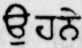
ਉਹਨੇ
